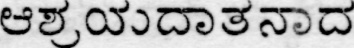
ಆಶ್ರಯದಾತನಾದ
